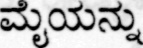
ಮೈಯನ್ನು
